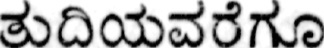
ತುದಿಯವರೆಗೂ
